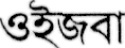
ওইজবা
